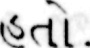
હતો.
